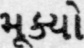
મૂક્યો
